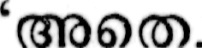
‘അതെ.
